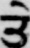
ਤੇ
